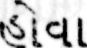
હોવા
